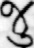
જુ
